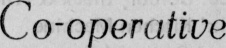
Co-operative
